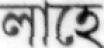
লাহে
